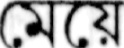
মেয়ে
